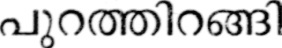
പുറത്തിറങ്ങി
